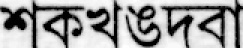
শকখঙদবা
